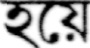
হয়ে
